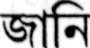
জানি
